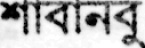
শাবানবু
